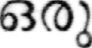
ഒരു
